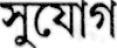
সুযোগ
